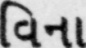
વિના
